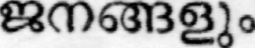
ജനങ്ങളും
